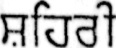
ਸ਼ਹਿਰੀ
